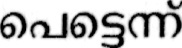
പെട്ടെന്ന്
